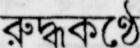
রুদ্ধকণ্ঠে
